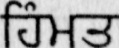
ਹਿੰਮਤ
